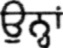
ਉਨ੍ਹਾਂ
